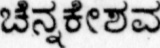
ಚೆನ್ನಕೇಶವ
